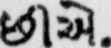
છીએ.
